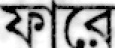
ফারে
